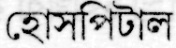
হোসপিটাল
